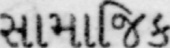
સામાજિક
